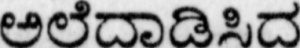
ಅಲೆದಾಡಿಸಿದ
